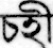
চহী
